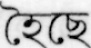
হৈছে
